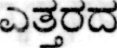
ಎತ್ತರದ
